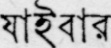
যাইবার
